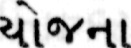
યોજના
